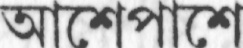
আশেপাশে
